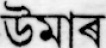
উমাৰ
